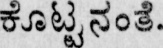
ಕೊಟ್ಟನಂತೆ.
